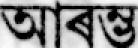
আৰম্ভ
